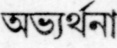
অভ্যর্থনা
